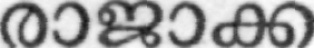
രാജാക്ക
